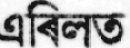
এৰিলত
